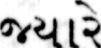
જ્યારે
